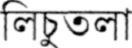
লিচুতলা
